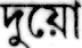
দুয়ো
